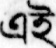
এই
